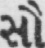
સૌ
